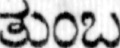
ತುಂಬ
